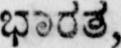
ಭಾರತ,
